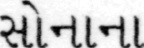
સોનાના
